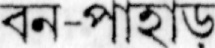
বন-পাহাড়
